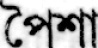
পৈশা
